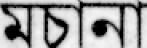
মচানা
